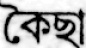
কৈছা
